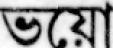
ভয়ো
